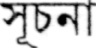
সূচনা
